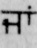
ਜਾਂ
